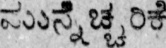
ಮುನ್ನೆಚ್ಚರಿಕೆ
